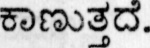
ಕಾಣುತ್ತದೆ.
